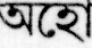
অহো
